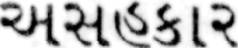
અસહકાર
